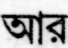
আর
